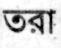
তরা
